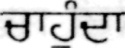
ਚਾਹੁੰਦਾ
